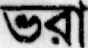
ভরা
